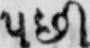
પછી
